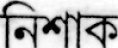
নিশাক
